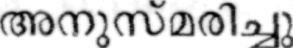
അനുസ്മരിച്ചു
